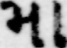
મા
